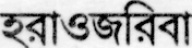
হরাওজরিবা
